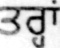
ਤਰ੍ਹਾਂ
